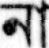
না
